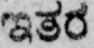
ಇತರ
